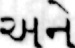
અને
